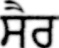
ਸੈਰ
